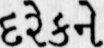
દરેકને
